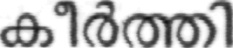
കീര്‍ത്തി
